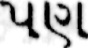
પણ
